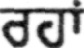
ਰਹਾਂ
